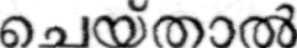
ചെയ്താല്‍
